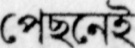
পেছনেই
